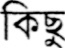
কিছু
